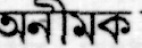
অনীমক
